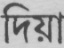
দিয়া
